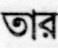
তার
